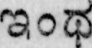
ಇಂಥ
